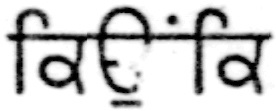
ਕਿਉਂਕਿ
